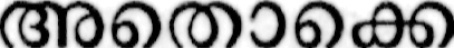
അതൊക്കെ
